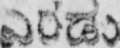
ಎರಡು
